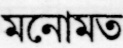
মনোমত
